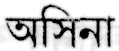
অসিনা
